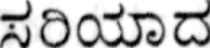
ಸರಿಯಾದ
